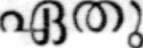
ഏതു
